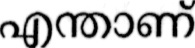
എന്താണ്
